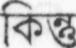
কিন্তু
